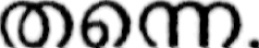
തന്നെ.
